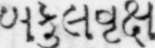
બકુલવૃક્ષ
